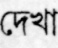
দেখা
